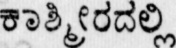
ಕಾಶ್ಮೀರದಲ್ಲಿ
